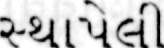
સ્થાપેલી
